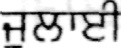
ਜੁਲਾਈ
